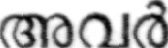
അവര്‍
